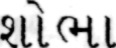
શોભા
